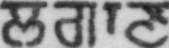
ਲਗਾਣ
